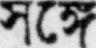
সঙ্গে
